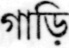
গাড়ি
